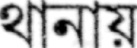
থানায়
